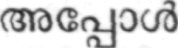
അപ്പോള്‍
